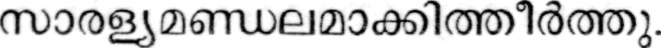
സാരള്യമണ്ഡലമാക്കിത്തീര്‍ത്തു.
